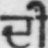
ਦੀ
